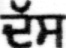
ਦੱਸ
